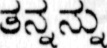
ತನ್ನನ್ನು
